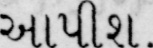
આપીશ.
